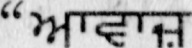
''ਆਵਾਜ਼
